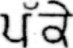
ਪੱਕੇ
